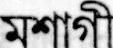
মশাগী
